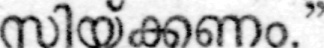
സിയ്ക്കണം."
